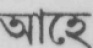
আহে
